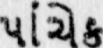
પાંચેક
